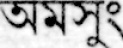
অমসুং
